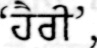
'ਹੈਰੀ',
